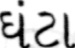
ધંટા
